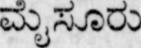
ಮೈಸೂರು
